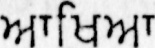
ਆਖਿਆ
